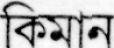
কিমান
